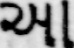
આ
